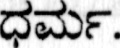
ಧರ್ಮ.
